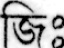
জিঃ
